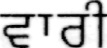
ਵਾਰੀ
